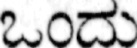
ಒಂದು
